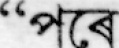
"পৰে
